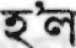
হ'ল
